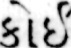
કોઈ
